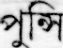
পুন্সি
